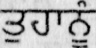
ਤੁਹਾਨੂੰ
